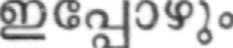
ഇപ്പോഴും
